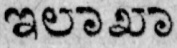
ಇಲಾಖಾ
